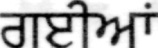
ਗਈਆਂ
